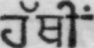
ਹੱਥੀਂ
